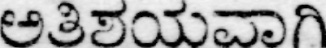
ಅತಿಶಯವಾಗಿ
